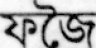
ফজৈ
